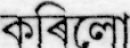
কৰিলো
